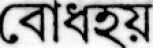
বোধহয়
